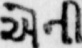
એની
